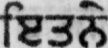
ਇਤਨੇ
